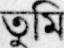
তুমি
